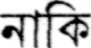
নাকি
